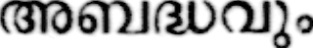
അബദ്ധവും
